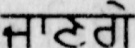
ਜਾਣਗੇ
